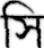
সি
